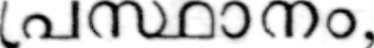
പ്രസ്ഥാനം,
